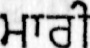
ਮਾਰੀ
